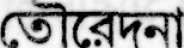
তৌরেদনা
